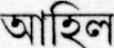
আহিল
